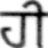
ਹੀ
